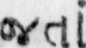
જતાં
